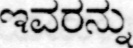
ಇವರನ್ನು
